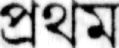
প্রথম
